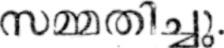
സമ്മതിച്ചു.
